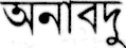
অনাবদু
